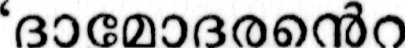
‘ദാമോദൻെറ
